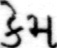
કેમ
